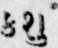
કશું
